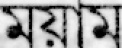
ময়াম
